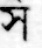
সি
